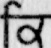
ਕਿ
